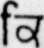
ਕਿ
